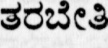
ತರಬೇತಿ
